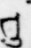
તું
